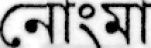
নোংমা
